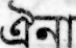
ঐনা
